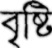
বৃষ্টি
